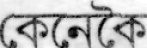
কেনেকৈ
